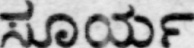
ಸೂರ್ಯ
